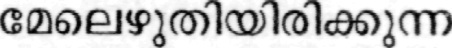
മേലെഴുതിയിരിക്കുന്ന
